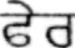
ਫੇਰ
